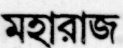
মহারাজ
